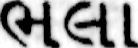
ભલા
